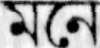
মনে
